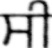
ਸੀ
